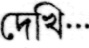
দেখি...
